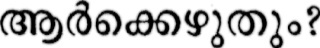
ആര്‍ക്കെഴുതും?
